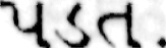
પડત.
